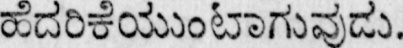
ಹೆದರಿಕೆಯುಂಟಾಗುವುದು.
